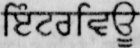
ਇੰਟਰਵਿਊ
